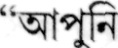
"আপুনি
